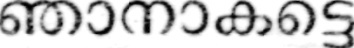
ഞാനാകട്ടെ
